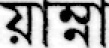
য়াম্না
